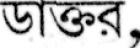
ডাক্তর,
